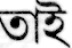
তাই
